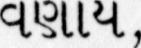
વણાય,
